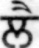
ਲੈ
